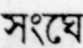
সংঘে
